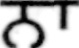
ਨਾ
